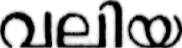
വലിയ
